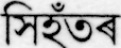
সিহঁতৰ
